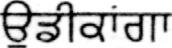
ਉਡੀਕਾਂਗਾ
